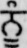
ਨੂੰ
